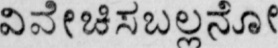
ವಿವೇಚಿಸಬಲ್ಲನೋ
